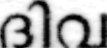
ദിവ
